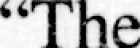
“The
